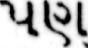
પણ
